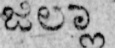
ಜಿಲ್ಲಾ
